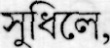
সুধিলে,
